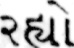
રહ્યો
